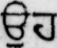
ਉਹ
